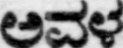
ಅವಳ
